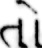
તો
